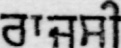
ਰਾਜਸੀ
